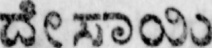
ದೇಸಾಯಿ
